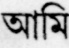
আমি
